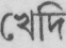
খেদি
